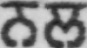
ਨਲ
